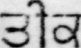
ਤੀਕ
